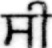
ਸੀ
